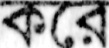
করে
